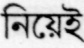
নিয়েই
